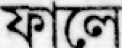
ফালে
